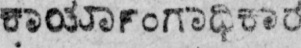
ಕಾರ್ಯಾಂಗಾಧಿಕಾರ
